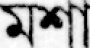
মশা
